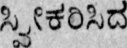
ಸ್ವೀಕರಿಸಿದ
